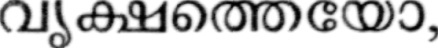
വൃക്ഷത്തെയോ,
